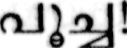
പൂച്ച!
